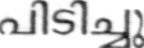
പിടിച്ചു
